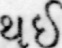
થઈ
